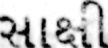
સાક્ષી
